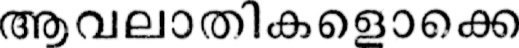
ആവലാതികളൊക്കെ
